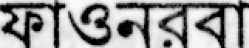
ফাওনরবা
